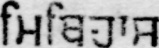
ਮਿਥਿਹਾਸ
